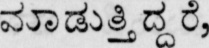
ಮಾಡುತ್ತಿದ್ದರೆ,
